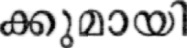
ക്കുമായി
